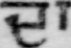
ਦਾ
